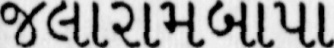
જલારામબાપા
